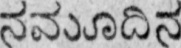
ನಮೂದಿನ
